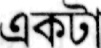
একটা
